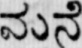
ಮನೆ
